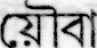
য়ৌবা
